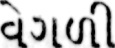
વેગળી
